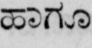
ಹಾಗೂ
